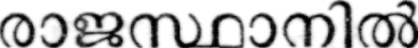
രാജസ്ഥാനില്‍
